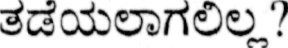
ತಡೆಯಲಾಗಲಿಲ್ಲ?
